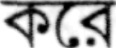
করে
